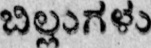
ಬಿಲ್ಲುಗಳ
